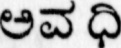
ಅವಧಿ
